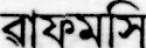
ৱাফমসি
